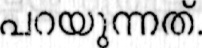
പറയുന്നത്.
